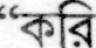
“করি
